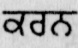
ਕਰਨ
